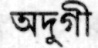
অদুগী
